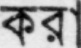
করা
